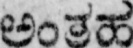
ಅಂತಹ
